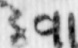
કેવા
